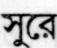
সুরে
